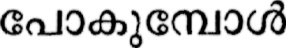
പോകുമ്പോള്‍
